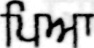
ਪਿਆ
